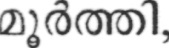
മൂര്‍ത്തി,
